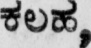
ಕಲಹ,
